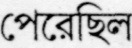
পেরেছিল
